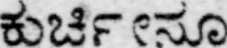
ಕುರ್ಚೀನೂ
